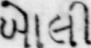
બોલી
